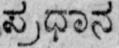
ಪ್ರಧಾನ
